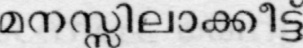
മനസ്സിലാക്കീട്ട്
